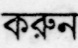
করুন
